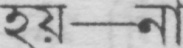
হয়-না
